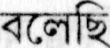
বলেছি
